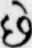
છે
